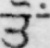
ਤੋਂ
